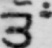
ਤੋਂ
